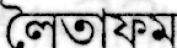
লৈতাফম
